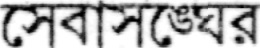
সেবাসঙ্ঘের
